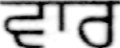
ਵਾਰ
